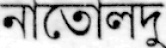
নাতোলদু
